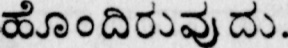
ಹೊಂದಿರುವುದು.
